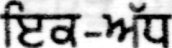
ਇਕ-ਅੱਧ
